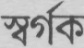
স্বৰ্গক
